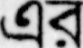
এর
